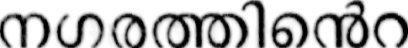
നഗരത്തിന്റെ
